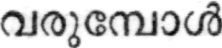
വരുമ്പോള്‍
